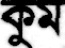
কুম
